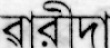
ৱারীদা
